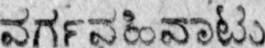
ವರ್ಗವಹಿವಾಟು
